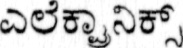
ಎಲೆಕ್ಟ್ರಾನಿಕ್ಸ್
